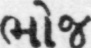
ભોજ
